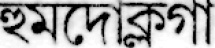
হুমদোক্লগা
